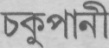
চকুপানী
